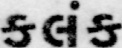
કલંક
